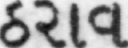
ઠરાવ
